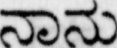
ನಾನು
